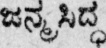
ಜನ್ಮಸಿದ್ಧ
